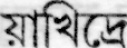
য়াখিদ্রে
